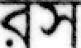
রস
